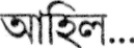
আহিল...
